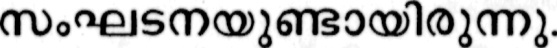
സംഘടനയുണ്ടായിരുന്നു.
